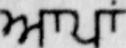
ਆਪਾਂ
